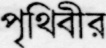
পৃথিবীর
